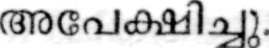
അപേക്ഷിച്ചു.
